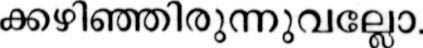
ക്കഴിഞ്ഞിരുന്നുവല്ലോ.
